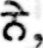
ਨੇ,
